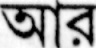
আর
